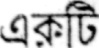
একটি
